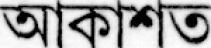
আকাশত
